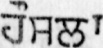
ਹੌਸਲਾ
